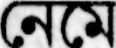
নেমে
